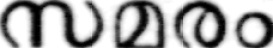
സമരം
